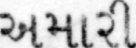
અમારી
